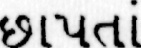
છાપતાં
